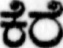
ಕೆರೆ
